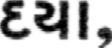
દયા,
